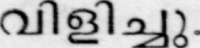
വിളിച്ചു.
